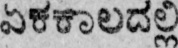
ಏಕಕಾಲದಲ್ಲಿ
